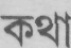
কথা
